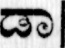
ಡಾ|
